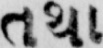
તથા
